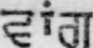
ਵਾਂਗ
